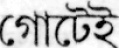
গোটেই
